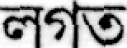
লগত
